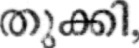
തുക്കി,
